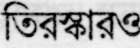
তিরস্কারও
